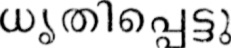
ധൃതിപ്പെട്ടു
